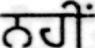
ਨਹੀਂ
